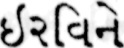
ઇરવિને
